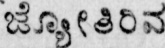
ಜ್ಯೋತಿರಿವ
